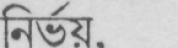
নিৰ্ভয়,
